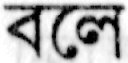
বলে
